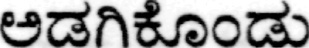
ಅಡಗಿಕೊಂಡು
